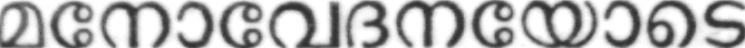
മനോവേദനയോടെ
